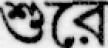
শুরে
